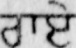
ਰਾਏ
